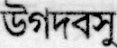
উগদবসু
